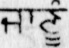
ਜਾਣੂੰ
